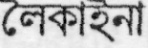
লৈকাইনা
